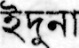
ইদুনা
